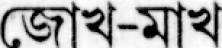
জোখ-মাখ
